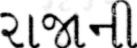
રાજાની
